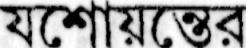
যশোয়ন্তের
